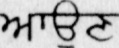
ਆਉਣ
